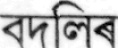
বদলিৰ
